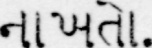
નાખતો.
